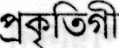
প্রকৃতিগী
